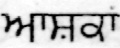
ਆਸ਼ਕਾਂ
